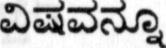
ವಿಷವನ್ನೂ
